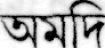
অমদি
